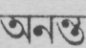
অনন্ত
